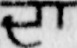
ਦਾ
